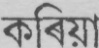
কৰিয়া
